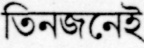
তিনজনেই
